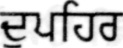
ਦੁਪਹਿਰ
